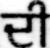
ਦੀ
